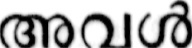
അവള്‍
